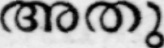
അതു
